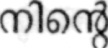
നിന്റെ
